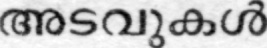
അടവുകള്‍
